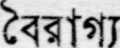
বৈরাগ্য
